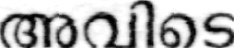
അവിടെ
